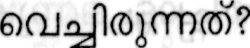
വെച്ചിരുന്നത്?
